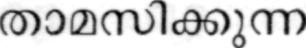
താമസിക്കുന്ന
